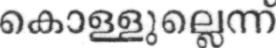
കൊള്ളുല്ലെന്ന്
